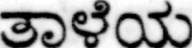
ತಾಳೆಯ
